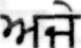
ਅਜੇ
